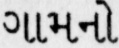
ગામનો
